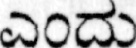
ಎಂದು
